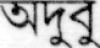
অদুবু
